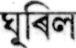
ঘূৰিল
